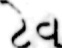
ટેવ
